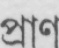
প্ৰাণ
